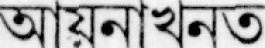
আয়নাখনত
